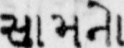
સામનો
